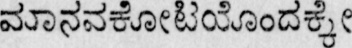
ಮಾನವಕೋಟಿಯೊಂದಕ್ಕೇ
